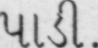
પાડી.
